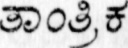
ತಾಂತ್ರಿಕ
